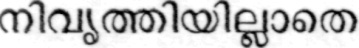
നിവൃത്തിയില്ലാതെ
